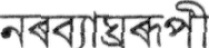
নৰব্যাঘ্ৰৰূপী
